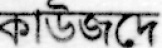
কাউজদে
